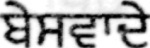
ਬੇਸਵਾਦੇ
